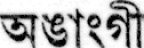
অঙাংগী
